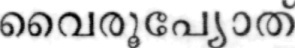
വൈരൂപ്യോത്
